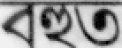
বহুত
